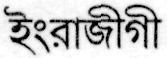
ইংরাজীগী
